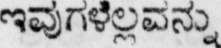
ಇವುಗಳೆಲ್ಲವನ್ನು
